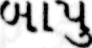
બાપુ
